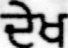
ਦੇਖ
